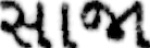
સાજા
